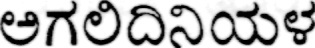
ಅಗಲಿದಿನಿಯಳ
